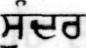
ਸੁੰਦਰ
